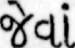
જેવાં
